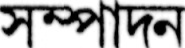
সম্পাদন
